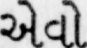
એવો
